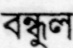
বন্ধুল
